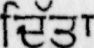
ਦਿੱਤਾ
